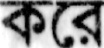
করে
